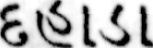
દહાડા
